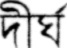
দীর্ঘ
